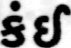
કંઈ
